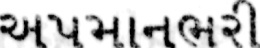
અપમાનભરી
